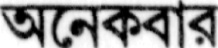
অনেকবার
